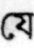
যে
